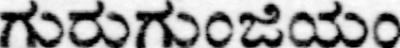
ಗುರುಗುಂಜಿಯಂ
